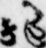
કહે
